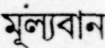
মূল্যবান
